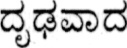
ದೃಢವಾದ
